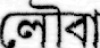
লৌবা
